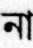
না
